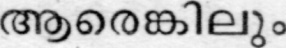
ആരെങ്കിലും
